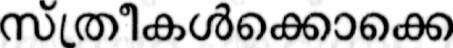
സ്ത്രീകള്‍ക്കൊക്കെ
